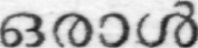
ഒരാള്‍
